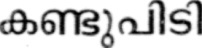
കണ്ടുപിടി
